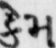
કેમ
